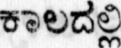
ಕಾಲದಲ್ಲಿ
